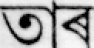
তাৰ
